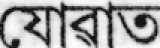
যোৱাত
